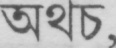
অথচ,
